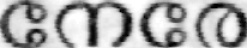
നേരേ
